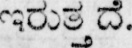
ಇರುತ್ತದೆ.
